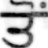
ਤੋਂ
